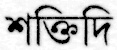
শক্তিদি
